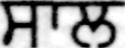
ਸਾਲ
